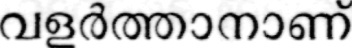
വളര്‍ത്താനാണ്
